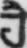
ਹੈ
